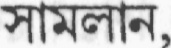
সামলান,
